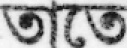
তাতে
